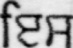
ਇਸ
